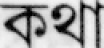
কথা
